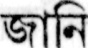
জানি
